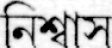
নিশ্বাস
